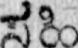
ಸಹಿ
